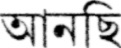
আনছি
